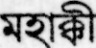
মহাক্কী
